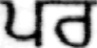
ਪਰ
